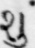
શું
